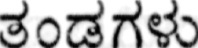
ತಂಡಗಳು
